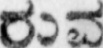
ರುವ
